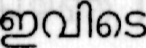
ഇവിടെ
